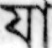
যা
